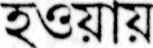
হওয়ায়
